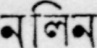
নলিন
